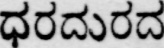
ಧರದುರದ
